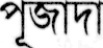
পূজাদা
